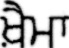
ਖ਼ੈਮਾ
